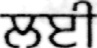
ਲਈ
